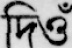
দিওঁ
